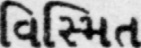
વિસ્મિત
